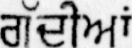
ਗੱਦੀਆਂ
